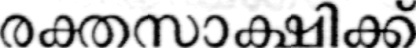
രക്തസാക്ഷിക്ക്
